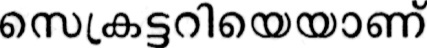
സെക്രട്ടറിയെയാണ്
